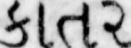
કાતર
